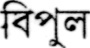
বিপুল
